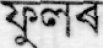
ফুলৰ
